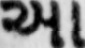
આ
